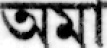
অমা
